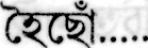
হৈছোঁ....
